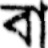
বা
